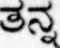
ತನ್ನ
